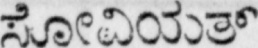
ಸೋವಿಯತ್
